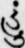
હું
